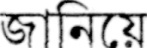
জানিয়ে
